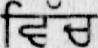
ਵਿੱਚ
